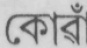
কোৱাঁ
